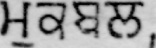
ਮੁਕਬਲ,
